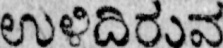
ಉಳಿದಿರುವ
